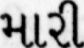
મારી
